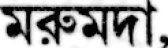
মরুমদা,
